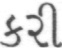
કરી
